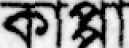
কাপ্পা
